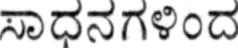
ಸಾಧನಗಳಿಂದ
